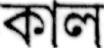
কাল
